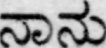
ನಾನು
